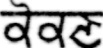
ਕੋਕਣ
